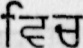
ਵਿਚ
